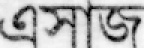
এসাজ
